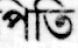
পিতি
